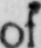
of
